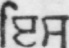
ਇਸ
